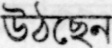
উঠছেন
